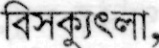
বিসক্যুৎলা,
